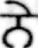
ਨੇ
